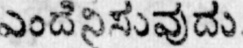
ಎಂದೆನಿಸುವುದು.
